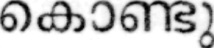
കൊണ്ടു
